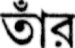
তাঁর
